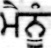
ਮੈਨੂੰ
